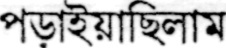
পড়াইয়াছিলাম
